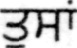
ਤੁਸਾਂ
